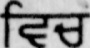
ਵਿਚ
